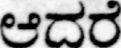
ಆದರೆ
